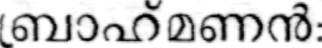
ബ്രാഹ്മണന്‍:
